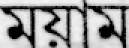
ময়াম
